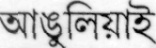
আঙুলিয়াই
